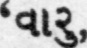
'વારુ,
